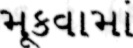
મૂકવામાં
